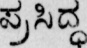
ಪ್ರಸಿದ್ಧ
